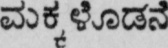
ಮಕ್ಕಳೊಡನೆ
